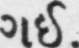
ગઈ.
